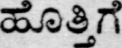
ಹೊತ್ತಿಗೆ
